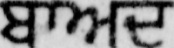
ਬਾਅਦ
